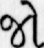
જો
